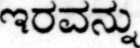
ಇರವನ್ನು
